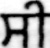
ਸੀ
